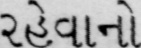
રહેવાનો
